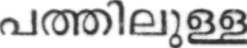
പത്തിലുള്ള
